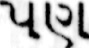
પણ
